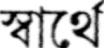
স্বার্থে
